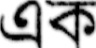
এক
